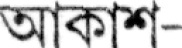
আকাশ-
